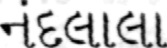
નંદલાલા
